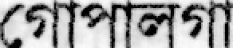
গোপালগা
